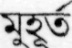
মুহূর্ত
